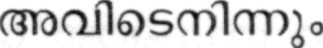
അവിടെനിന്നും
